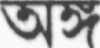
অঙ্গ
